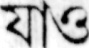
যাও
